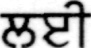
ਲਈ
